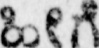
ಹೀಗೆ
